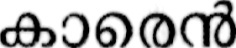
കാരെന്‍
